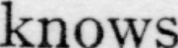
knows
